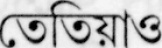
তেতিয়াও
